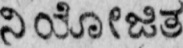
ನಿಯೋಜಿತ
